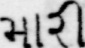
મારી
